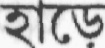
হাড়ে
